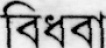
বিধবা
